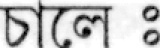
চালেঃ
